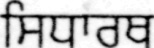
ਸਿਧਾਰਥ
